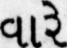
વારે
